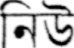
নিউ
